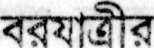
বরযাত্রীর
